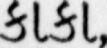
કાકા,
